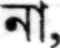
না,
